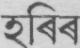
হৰিৰ
